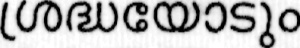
ശ്രദ്ധയോടും
